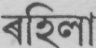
ৰহিলা
